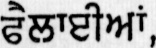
ਫੈਲਾਈਆਂ,
